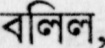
বলিল,
